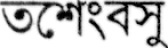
তশেংবসু
